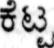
ಕೆಟ್ಟ
